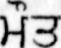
ਮੌਤ
